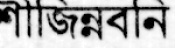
শীজিন্নবনি
